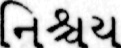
નિશ્ચય
